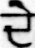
ਦੇ
